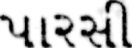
પારસી
